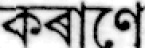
কৰাণে
